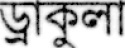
ড্রাকুলা
